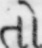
તો
